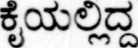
ಕೈಯಲ್ಲಿದ್ದ
